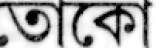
তোকো
